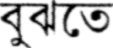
বুঝতে
